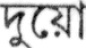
দুয়ো
